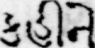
કહીને
